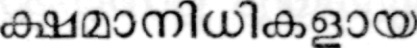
ക്ഷമാനിധികളായ
